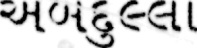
અબદુલ્લા
